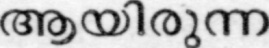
ആയിരുന്ന
